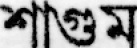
শাগুম
